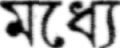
মধ্যে
